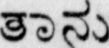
ತಾನು
